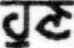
ਹੁਣ
